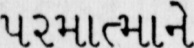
પરમાત્માને
